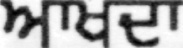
ਆਖਦਾ
